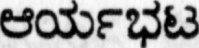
ಆರ್ಯಭಟ
